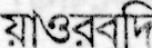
য়াওরবদি
